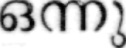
ഒന്നു
